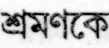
শ্রমণকে
